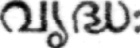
വൃദ്ധ:
